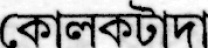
কোলকটাদা
